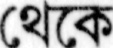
থেকে
